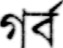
গর্ব
